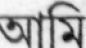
আমি
